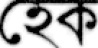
হেক
